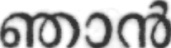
ഞാന്‍
